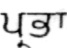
ਪ੍ਰਭਾ
